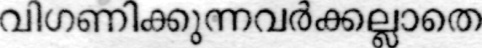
വിഗണിക്കുന്നവര്‍ക്കല്ലാതെ
